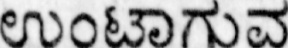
ಉಂಟಾಗುವ
